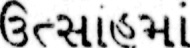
ઉત્સાહમાં
